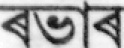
ৰভাৰ
